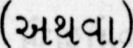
(અથવા)
